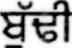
ਬੁੱਢੀ
